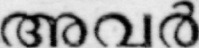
അവര്‍
